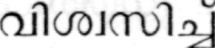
വിശ്വസിച്ച്
